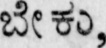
ಬೇಕು,
